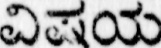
ವಿಷಯ
